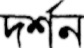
দর্শন
